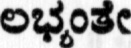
ಲಭ್ಯಂತೇ
